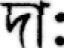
দা:
